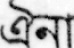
ঐনা
